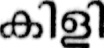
കിളി
